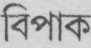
বিপাক
